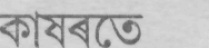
কাষৰতে
